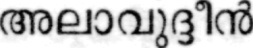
അലാവുദ്ദീന്‍
